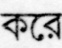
করে
